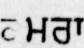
ਕਮਰਾ
